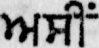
ਅਸੀਂ
